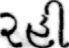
રહી
